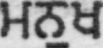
ਮਨੁਖ
